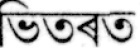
ভিতৰত
